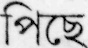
পিছে
